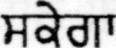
ਸਕੇਗਾ
